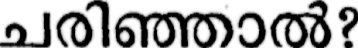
ചരിഞ്ഞാല്‍?
